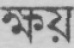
ক্ষয়
